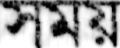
সময়
